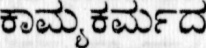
ಕಾಮ್ಯಕರ್ಮದ
